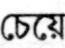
চেয়ে
